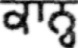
ਕਾਨ੍ਹ
